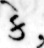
કે,
